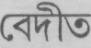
বেদীত
